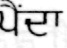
ਪੈਂਦਾ
